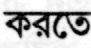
করতে
